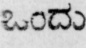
ಒಂದು
